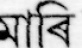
মাৰি
